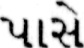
પાસે
